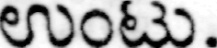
ಉಂಟು.
